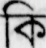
কি
